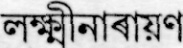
লক্ষ্মীনাৰায়ণ
